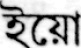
ইয়ো
